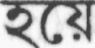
হয়ে
